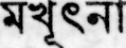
মখূৎনা
